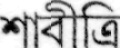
শাবীত্রি
